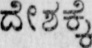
ದೇಶಕ್ಕೆ
